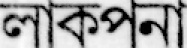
লাকপনা
